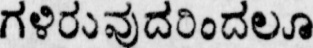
ಗಳಿರುವುದರಿಂದಲೂ
